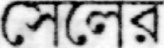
সেলের
